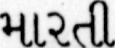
મારતી
